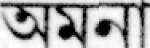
অমনা
